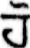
ਹੋ
